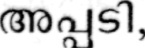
അപ്പടി,
